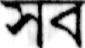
সব
